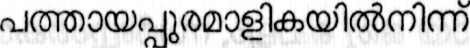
പത്തായപ്പുരമാളികയില്‍നിന്ന്
